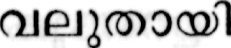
വലുതായി
